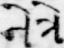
નેત્રે
